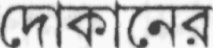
দোকানের
